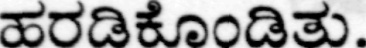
ಹರಡಿಕೊಂಡಿತು.
